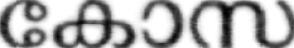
കോസ
